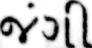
જંગી
